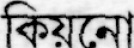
কিয়নো
